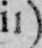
ii)
